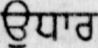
ਉਧਾਰ
